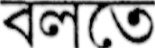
বলতে
